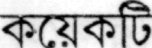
কয়েকটি
